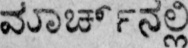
ಮಾರ್ಚ್‌ನಲ್ಲಿ
